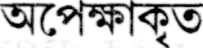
অপেক্ষাকৃত
